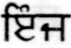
ਇੰਜ
